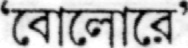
‘বোলোরে’
